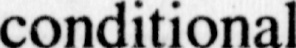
conditional
